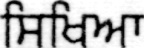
ਸਿਖਿਆ
